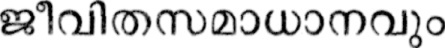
ജീവിതസമാധാനവും
